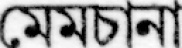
মেমচানা
